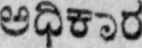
ಅಧಿಕಾರ
